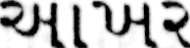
આખર
